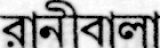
রানীবালা
